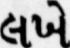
લખે
